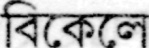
বিকেলে
